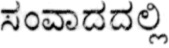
ಸಂವಾದದಲ್ಲಿ
